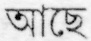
আছে
